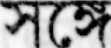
সঙ্গে
